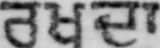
ਰਖਦਾ
